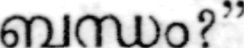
ബന്ധം?”
